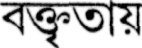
বক্তৃতায়
